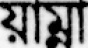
য়াম্না
